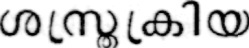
ശസ്ത്രക്രിയ
